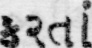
કરતાં
